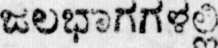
ಜಲಭಾಗಗಳಲ್ಲಿ
